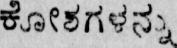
ಕೋಶಗಳನ್ನು
